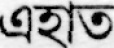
এহাত
